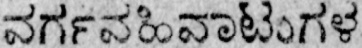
ವರ್ಗವಹಿವಾಟುಗಳ
